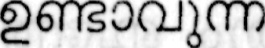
ഉണ്ടാവുന്ന
